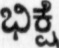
ಭಿಕ್ಷೆ
